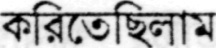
করিতেছিলাম
